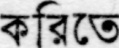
করিতে
